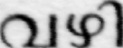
വഴി
